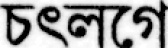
চৎলগে
